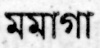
মমাগা
